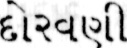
દોરવણી
